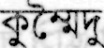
কুম্মৈদু
